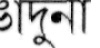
ঙাদুনা
